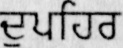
ਦੁਪਹਿਰ
